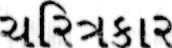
ચરિત્રકાર
